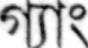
গ্যাং
